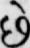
છે
